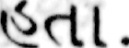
હતા.
